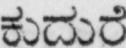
ಕುದುರೆ
